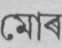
মোৰ
